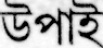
উপাই
